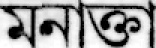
মনাক্তা
